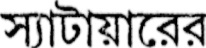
স্যাটায়ারের
